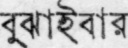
বুঝাইবার
